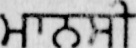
ਮਾਨਸੀ
